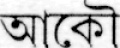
আকৌ
